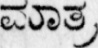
ಮಾತ್ರ
